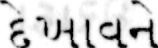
દેખાવને
